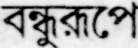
বন্ধুরূপে
